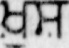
ਖ਼ੁਸ਼
